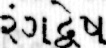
રંગદ્વેષ
